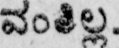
ವಂತಿಲ್ಲ.
